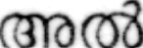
അല്‍
